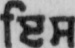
ਇਸ
